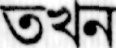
তখন
